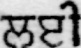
ਲਈ
